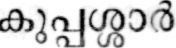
കുപ്പശ്ശാര്‍
